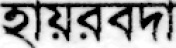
হায়রবদা
